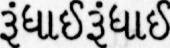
રૂંધાઈરૂંધાઈ
